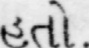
હતો.
